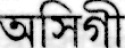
অসিগী
